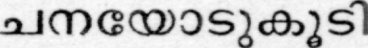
ചനയോടുകൂടി
